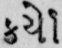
કર્યો
